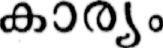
കാര്യം
